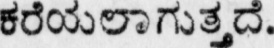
ಕರೆಯಲಾಗುತ್ತದೆ.
